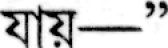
যায়-"
